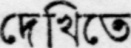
দেখিতে
